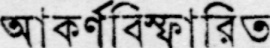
আকর্ণবিস্ফারিত
